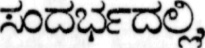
ಸಂದರ್ಭದಲ್ಲಿ,
